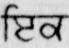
ਇਕ
